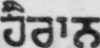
ਹੈਰਾਨ
